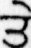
ਤੇ
